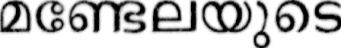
മണ്ടേലയുടെ
